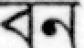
বন
